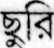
ছুরি
